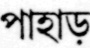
পাহাড়
